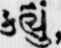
કહ્યું,
